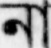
না
